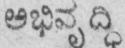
ಅಭಿವೃದ್ಧಿ
